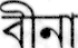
বীনা
